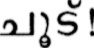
ചൂട്!
